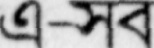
এ-সব
